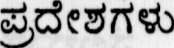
ಪ್ರದೇಶಗಳು
